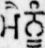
ਮੈਨੂੰ
